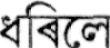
ধৰিলে
